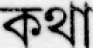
কথা
